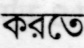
করতে
